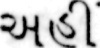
અહીં
